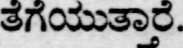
ತೆಗೆಯುತ್ತಾರೆ.
